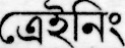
ত্রেইনিং
